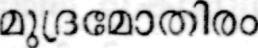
മുദ്രമോതിരം
